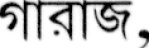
গারাজ,
